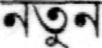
নতুন
